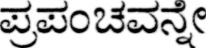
ಪ್ರಪಂಚವನ್ನೇ
